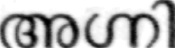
അഗ്നി
